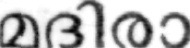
മദിരാ
